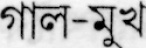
গাল-মুখ
